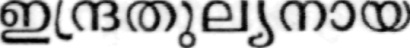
ഇന്ദ്രതുല്യനായ
